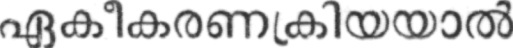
ഏകീകരണക്രിയയാല്‍
